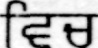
ਵਿਚ
